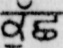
ਕੁੱਛ
